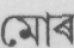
মোৰ
